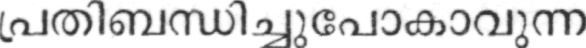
പ്രതിബന്ധിച്ചുപോകാവുന്ന
